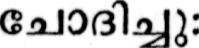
ചോദിച്ചു:
